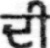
ਦੀ
